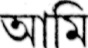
আমি
